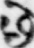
છે
